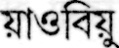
য়াওবিয়ু
